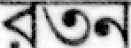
রতন
